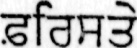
ਫ਼ਰਿਸਤੇ
